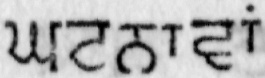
ਘਟਨਾਵਾਂ
